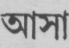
আসা
